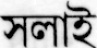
সলাই
